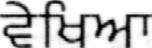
ਵੇਖਿਆ
